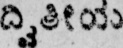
ದ್ವಿತೀಯ
